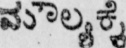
ಮೌಲ್ಯಕ್ಕೆ
